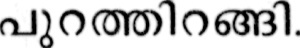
പുറത്തിറങ്ങി.
